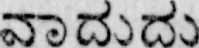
ವಾದುದು
